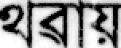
থৱায়
